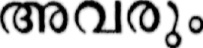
അവരും
